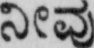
ನೀವು
